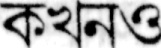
কখনও
